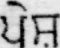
ਪੇਸ਼
